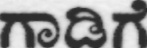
ಗಾಡಿಗೆ
